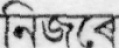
নিজৰে
